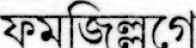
ফমজিল্লগে
